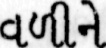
વળીને
